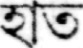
হাত
